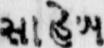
સાહેબ
